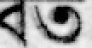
বত
